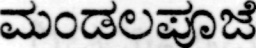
ಮಂಡಲಪೂಜೆ
